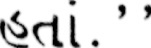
હતાં."
